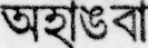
অহাঙবা
